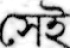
সেই
